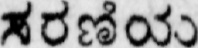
ಸರಣಿಯ
